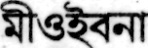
মীওইবনা
